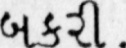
બકરી.
